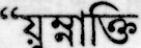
“য়ুম্নাক্তি
